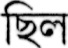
ছিল
